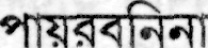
পায়রবনিনা
